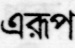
এরূপ
